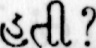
હતી?
